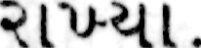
રાખ્યા.
